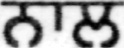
ਨਾਲ
